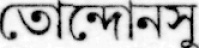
তোন্দোনসু
